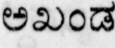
ಅಖಂಡ
